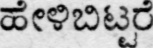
ಹೇಳಿಬಿಟ್ಟರೆ
